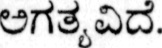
ಅಗತ್ಯವಿದೆ.
